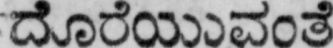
ದೊರೆಯುವಂತೆ
